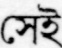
সেই
